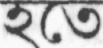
হতে
